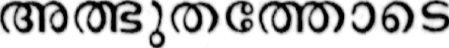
അത്ഭുതത്തോടെ
